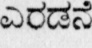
ಎರಡನೆ
